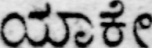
ಯಾಕೇ
